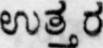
ಉತ್ತರ
